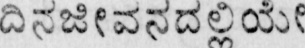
ದಿನಜೀವನದಲ್ಲಿಯೇ
